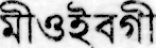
মীওইবগী
